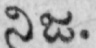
ನಿಜ.
